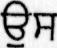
ਉਸ
